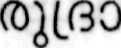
രുദ്രാ
